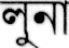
লুনা
